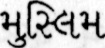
મુસ્લિમ
